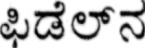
ಫಿಡೆಲ್ನ
